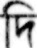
দি
